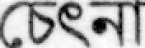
চেৎনা
